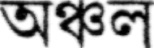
অঞ্চল
